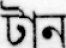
টান
